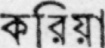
করিয়া
